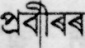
প্রবীৰৰ
